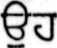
ਉਹ
